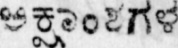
ಅಕ್ಷಾಂಶಗಳ
